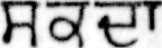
ਸਕਦਾ
